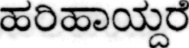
ಹರಿಹಾಯ್ದರೆ
